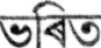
ভৰিত
